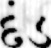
દંડ
